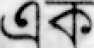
এক
